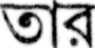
তার
